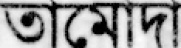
তামোদা
